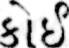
કોઈ
